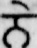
ਨੇ
